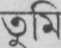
তুমি
